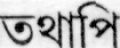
তথাপি
